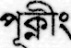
পূক্নীং
